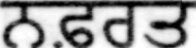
ਨਫ਼ਰਤ
